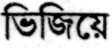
ভিজিয়ে
